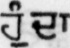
ਹੁੰਦਾ
